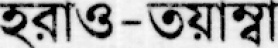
হরাও-তয়াম্বা
